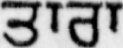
ਤਾਰਾ
